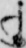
તું
